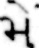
મેં
